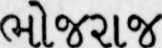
ભોજરાજ
